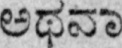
ಅಥವಾ
